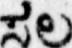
ಸಲ
